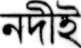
নদীই
